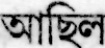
আছিল
